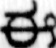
ಈ
